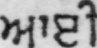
ਆਈ
